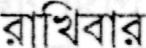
রাখিবার
